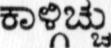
ಕಾಳ್ಗಿಚ್ಚು
